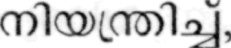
നിയന്ത്രിച്ച്,
